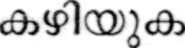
കഴിയുക
